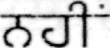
ਨਹੀਂ
